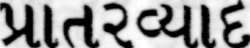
પ્રાતરવ્યાદ
